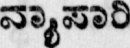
ವ್ಯಾಪಾರಿ
